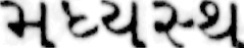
મધ્યસ્થ
